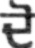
ਦੋ
